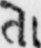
તો
